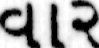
વાર
